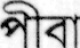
পীবা
